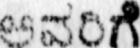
ಅವರಿಗೆ
